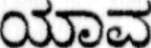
ಯಾವ
